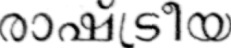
രാഷ്ട്രീയ
